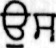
ਉਸ
